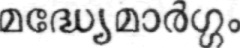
മദ്ധ്യേമാര്‍ഗ്ഗം
